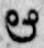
ಆ
